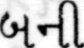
બની
